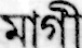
মাগী
